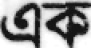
এক
